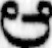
ಆ
